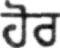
ਹੋਰ
